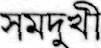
সমদুখী
